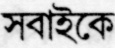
সবাইকে
